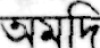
অমদি
